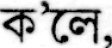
ক'লে,
